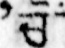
'ਚੋਂ
